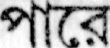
পারে
